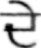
ਦੇ
